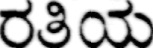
ರತಿಯ
